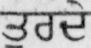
ਤੁਰਦੇ
